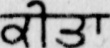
ਕੀਤਾ
